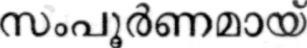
സംപൂര്‍ണമായ്
